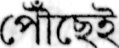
পৌঁছেই
